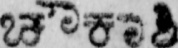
ಚೌಕಾಶಿ
